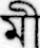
মী
